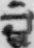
ਦੇ
